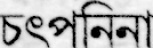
চৎপনিনা
